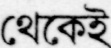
থেকেই
